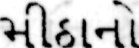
મીઠાનો
